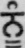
ਨੂੰ
